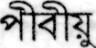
পীবীয়ু
